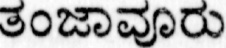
ತಂಜಾವೂರು
